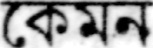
কেমন
